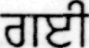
ਗਈ
